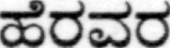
ಹೆರವರ
